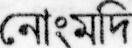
নোংমদি
